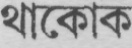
থাকোক
